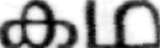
കഥ
